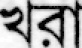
খরা
